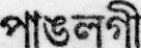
পাঙলগী
